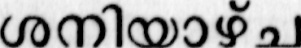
ശനിയാഴ്ച
